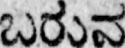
ಬರುವ
